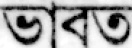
ভাবত
